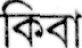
কিবা
